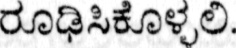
ರೂಢಿಸಿಕೊಳ್ಳಲಿ.
